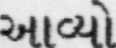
આવ્યો
